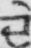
ਦੇ
